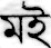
মই
